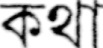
কথা
